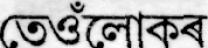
তেওঁলোকৰ
